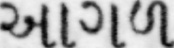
આગળ
